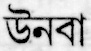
উনবা
